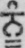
ਨੂੰ
